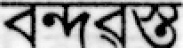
বন্দৱস্ত
